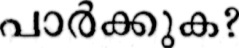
പാര്‍ക്കുക?
